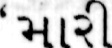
'મારી
